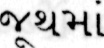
જૂથમાં
